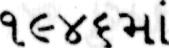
૧૯૪૬માં
